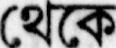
থেকে
